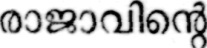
രാജാവിന്റെ
